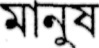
মানুষ
